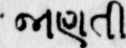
જાણતી
